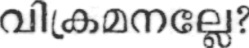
വിക്രമനല്ലേ?
